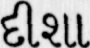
દીશા
